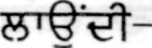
ਲਾਉਂਦੀ-
